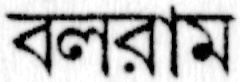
বলরাম
